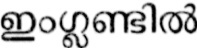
ഇംഗ്ളണ്ടില്‍
